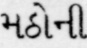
મઠોની
